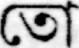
তো
